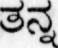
ತನ್ನ
